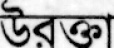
উরক্তা
